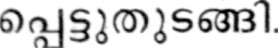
പ്പെട്ടുതുടങ്ങി.
